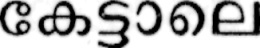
കേട്ടാലെ
